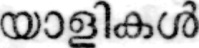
യാളികള്‍
